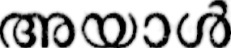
അയാള്‍
